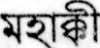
মহাক্কী
